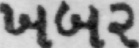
ખબર
